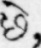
છે,
